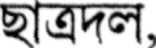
ছাত্রদল,
